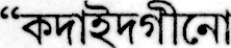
“কদাইদগীনো
